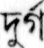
দুর্গ
